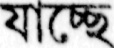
যাচ্ছে
